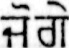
ਜੋਗੇ
